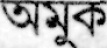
অমুক
